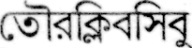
তৌরক্লিবসিবু
